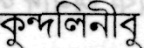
কুন্দলিনীবু
